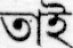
তাই
